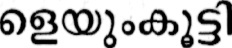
ളെയുംകൂട്ടി
